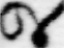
જ
